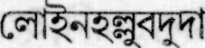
লোইনহল্লুবদুদা
